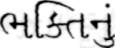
ભક્તિનું
